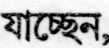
যাচ্ছেন,
